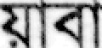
য়াবা
